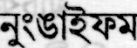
নুংঙাইফম
